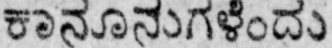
ಕಾನೂನುಗಳೆಂದು
